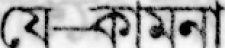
যে-কামনা
